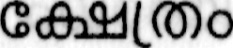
ക്ഷേത്രം
